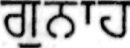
ਗੁਨਾਹ
